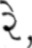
રે,
